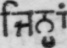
ਜਿਨ੍ਹਾਂ
